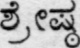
ಶ್ರೇಷ್ಠ
